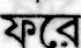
ফরে
